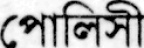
পোলিসী
